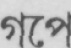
গপে
